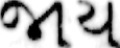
જાય
